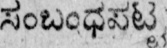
ಸಂಬಂಧಪಟ್ಟ
